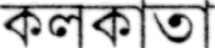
কলকাতা
